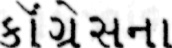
કૉંગ્રેસના
